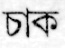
চাক
